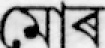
মোৰ
